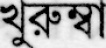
খুরুম্বা
